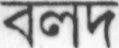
বলদ
